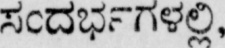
ಸಂದರ್ಭಗಳಲ್ಲಿ,
